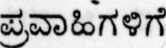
ಪ್ರವಾಹಿಗಳಿಗೆ
